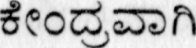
ಕೇಂದ್ರವಾಗಿ
